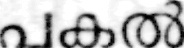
പകല്‍
